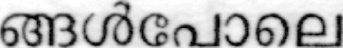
ങ്ങള്‍പോലെ
